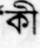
‘কী
